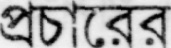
প্রচারের
